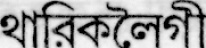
থারিকলৈগী
